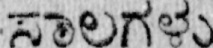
ಸಾಲಗಳು.
